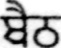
ਬੈਠ
